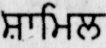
ਸ਼ਾਮਿਲ
